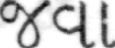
જવા
